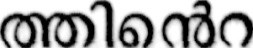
ത്തിന്റെ
